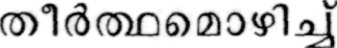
തീര്‍ത്ഥമൊഴിച്ച്
